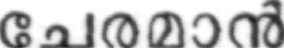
ചേരമാന്‍
